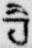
ਹੈ
